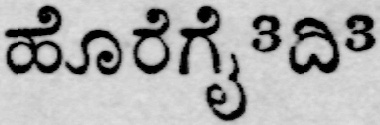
ಹೊರೆಗೈ3ದಿ3
